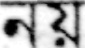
নয়
